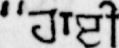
''ਹਾਈ
